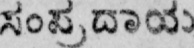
ಸಂಪ್ರದಾಯ
